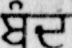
ਬੰਦ
